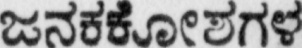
ಜನಕಕೋಶಗಳ
